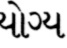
યોગ્ય
